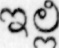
ಇಲ್ಲಿ
